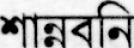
শান্নবনি
